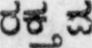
ರಕ್ತದ
